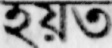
হয়ত
